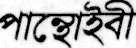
পান্থোইবী
